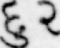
દુર
